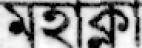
মহাক্না
